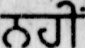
ਨਹੀਂ
